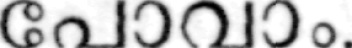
പോവാം.
